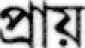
প্রায়
